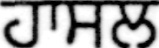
ਹਾਸਲ
